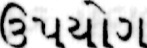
ઉપયોગ
